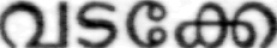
വടക്കേ
